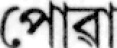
পোৱা
